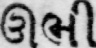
ઊભી
